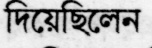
দিয়েছিলেন
